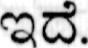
ಇದೆ.
